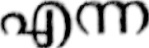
എന്ന
